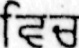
ਵਿਚ
